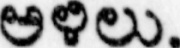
ಅಳಿಲು,
